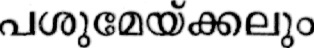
പശുമേയ്ക്കലും
